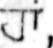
ਹਾਂ,
